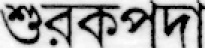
শুরকপদা
